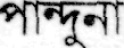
পান্দুনা
